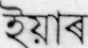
ইয়াৰ
